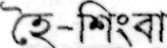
হৈ-শিংবা
